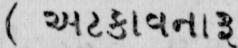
(અટકાવનારૂ
